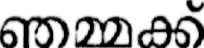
ഞമ്മക്ക്
